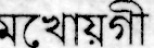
মখোয়গী
